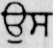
ਉਸ
